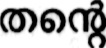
തന്റെ
